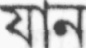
যান
